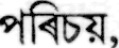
পৰিচয়,
